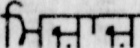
ਮਿਜ਼ਾਜ਼
